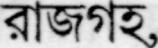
রাজগহ,
